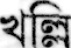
খল্লি
